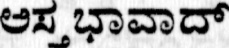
ಅಸ್ತಭಾವಾದ್
